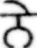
ਨੇ
